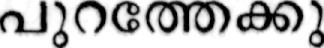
പുറത്തേക്കു
